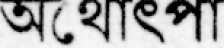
অথোৎপা
